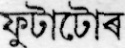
ফুটাটোৰ
